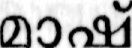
മാഷ്
